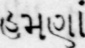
હમણાં
